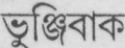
ভুঞ্জিবাক
